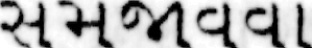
સમજાવવા
